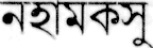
নহামকসু
